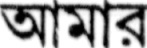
আমার
